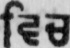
ਵਿਚ
